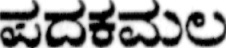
ಪದಕಮಲ
